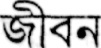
জীবন
